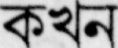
কখন
